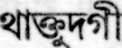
থাক্তুদগী
